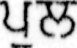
ਪੁਲ
